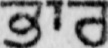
ਭਾਰ
